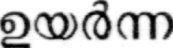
ഉയര്‍ന്ന
